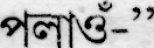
পলাওঁ-"
